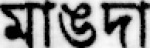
মাঙদা
